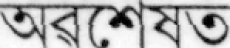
অৱশেষত
